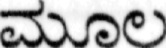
ಮೂಲ
